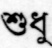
শুধু
